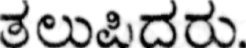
ತಲುಪಿದರು.
